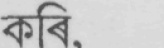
কৰি,
